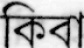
কিবা
